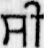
ਸੀ
